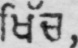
ਖਿੱਚ,
